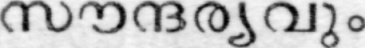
സൌന്ദര്യവും
